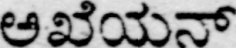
ಅಖೆಯನ್
